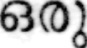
ഒരു
